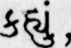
કહ્યું,
